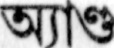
অ্যাণ্ড
